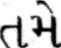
તમે
